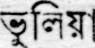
ভুলিয়া
